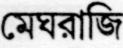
মেঘরাজি
